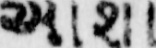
આશા
